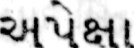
અપેક્ષા
